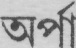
অৰ্পা
